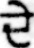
ਦੇ
